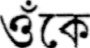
ওঁকে
